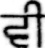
ਵੀ
